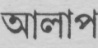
আলাপ
